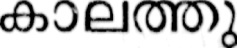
കാലത്തു
